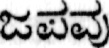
ಜಪವು
